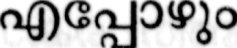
എപ്പോഴും
